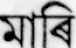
মাৰি
